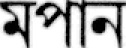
মপান
